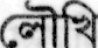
লৌখি
